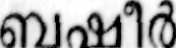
ബഷീര്‍
